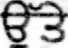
ਉੱਤੇ
